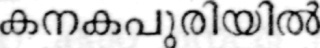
കനകപുരിയില്‍
